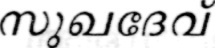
സുഖദേവ്
